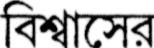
বিশ্বাসের
